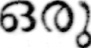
ഒരു
